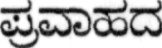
ಪ್ರವಾಹದ
